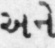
અને
